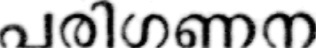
പരിഗണന
